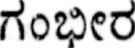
ಗಂಭೀರ
